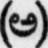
(ಅ)
